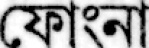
ফোংনা
